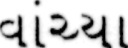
વાંચ્યા
